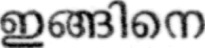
ഇങ്ങിനെ
